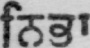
ਨਿਭਾ
